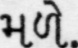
મળે.
